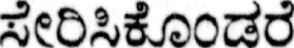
ಸೇರಿಸಿಕೊಂಡರೆ
